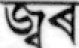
জ্বৰ
